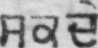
ਸਕਦੇ
